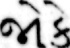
જોકે
